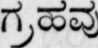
ಗ್ರಹವು
